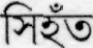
সিহঁত
